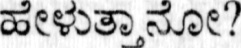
ಹೇಳುತ್ತಾನೋ?
